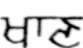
ਖਾਣ
